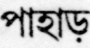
পাহাড়
